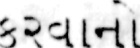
કરવાનો
